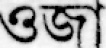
ওজা
